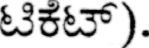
ಟಿಕೆಟ್).
